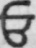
ਓ
